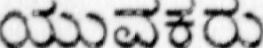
ಯುವಕರು
